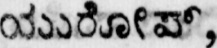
ಯುರೋಪ್,
